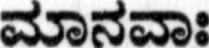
ಮಾನವಾಃ
